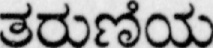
ತರುಣಿಯ
